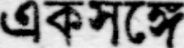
একসঙ্গে
